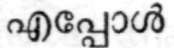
എപ്പോള്‍
